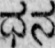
ಧನ
